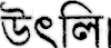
উৎলি।
